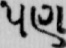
પણ
